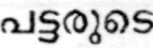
പട്ടരുടെ
